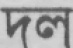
দল
